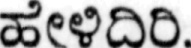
ಹೇಳಿದಿರಿ.
